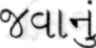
જવાનું
